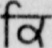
ਕਿ
